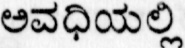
ಅವಧಿಯಲ್ಲಿ
